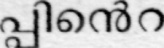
പ്പിന്റെ
